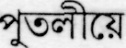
পুতলীয়ে
